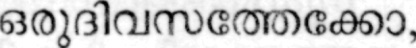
ഒരുദിവസത്തേക്കോ,
